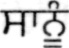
ਸਾਨੂੰ
